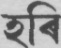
হৰি
